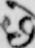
છે
